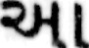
આ
